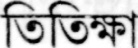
তিতিক্ষা
